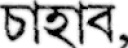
চাহাব,
